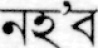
নহ'ব
